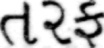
તરફ
